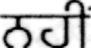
ਨਹੀਂ
